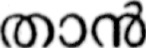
താന്‍
